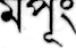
মপূং
